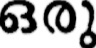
ഒരു
